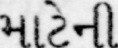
માટેની
